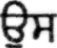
ਉਸ
